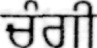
ਚੰਗੀ
